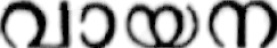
വായന
